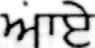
ਆਏ
